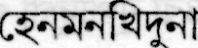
হেনমনখিদুনা
